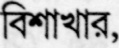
বিশাখার,
